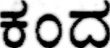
ಕಂದ
